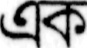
এক
